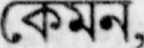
কেমন,
